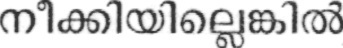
നീക്കിയില്ലെങ്കില്‍
